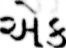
એક
